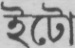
ইটো
